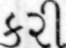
કરી
